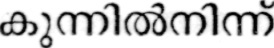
കുന്നില്‍നിന്ന്
